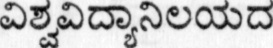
ವಿಶ್ವವಿದ್ಯಾನಿಲಯದ
